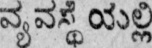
ವ್ಯವಸ್ಥೆಯಲ್ಲಿ
